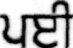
ਪਈ
